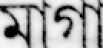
মাগা
